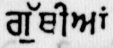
ਗੁੱਥੀਆਂ
